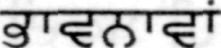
ਭਾਵਨਾਵਾਂ
